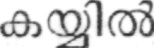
കയ്യില്‍
